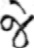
જેજે
